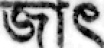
জাৎ
